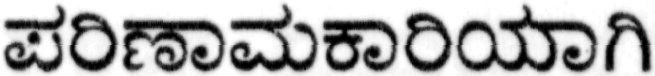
ಪರಿಣಾಮಕಾರಿಯಾಗಿ
